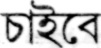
চাইবে
